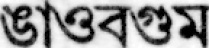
ঙাওবগুম
